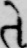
તે
